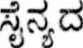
ಸೈನ್ಯದ
